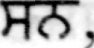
ਸਨ,
